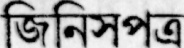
জিনিসপত্র
